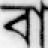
বা
